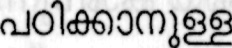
പഠിക്കാനുള്ള
